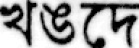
খঙদে
